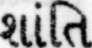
શાંતિ
